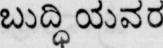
ಬುದ್ಧಿಯವರ
